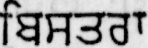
ਬਿਸਤਰਾ
